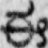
ಈ
